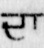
ਦਾ
